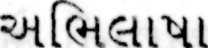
અભિલાષા
